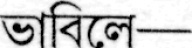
ভাবিলে-
